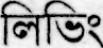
লিভিং
